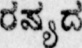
ರಷ್ಯದ
